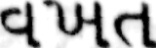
વખત
